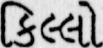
કિલ્લો
